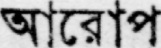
আরোপ
